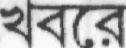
খবরে
